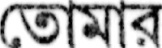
তোমার
